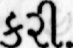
કરી.
